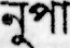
নুপা
